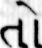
તો
